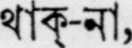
থাক্-না,
